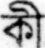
কী
